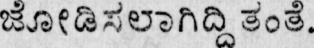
ಜೋಡಿಸಲಾಗಿದ್ದಿತಂತೆ.
